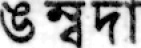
ঙম্বদা
